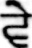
ਵੇ
